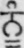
ਨੂੰ
